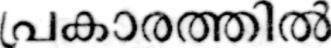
പ്രകാരത്തില്‍
